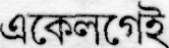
একেলগেই
